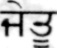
ਜੇਤੂ
